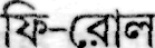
ফি-রোল
